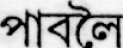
পাবলৈ
